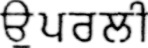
ਉਪਰਲੀ
